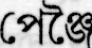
পেঞ্জৈ
